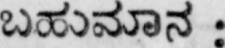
ಬಹುಮಾನ:
